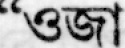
“ওজা
